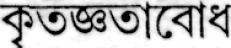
কৃতজ্ঞতাবোধ
